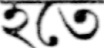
হতে
